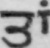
ਤਾਂ
